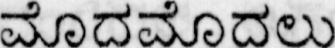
ಮೊದಮೊದಲು
